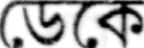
ডেকে
